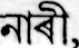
নাৰী,
